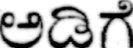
ಅಡಿಗೆ
